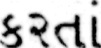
કરતાં
